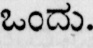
ಒಂದು.
